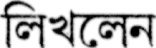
লিখলেন
